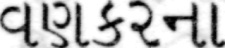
વણકરના
